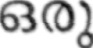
ഒരു
